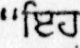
''ਇਹ
